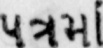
પત્રમાં
